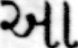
આ
